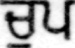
ਚੁਪ
